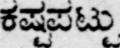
ಕಷ್ಟಪಟ್ಟು
